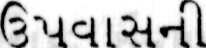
ઉપવાસની
